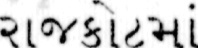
રાજકોટમાં
